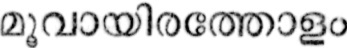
മൂവായിരത്തോളം
